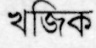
খজিক
